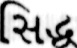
સિદ્ધ
